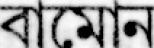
বামোন
